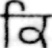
ਕਿ
